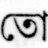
তো
